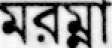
মরম্না
